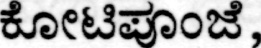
ಕೋಟಿಪೂಂಜೆ,
